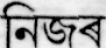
নিজৰ
